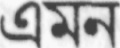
এমন
